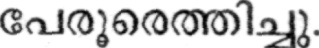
പേരൂരെത്തിച്ചു.
